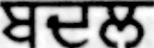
ਬਦਲ
